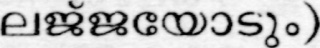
ലജ്ജയോടും)
